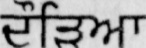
ਦੌੜਿਆ
